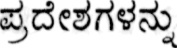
ಪ್ರದೇಶಗಳನ್ನು
